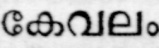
കേവലം
